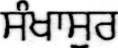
ਸੰਖਾਸੁਰ
